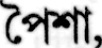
পৈশা,
